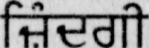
ਜ਼ਿੰਦਗੀ
